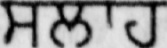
ਸਲਾਹ
